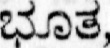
ಭೂತ,
